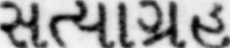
સત્યાગ્રહ
